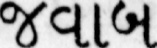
જવાબ
